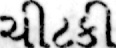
ચીટકી
